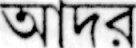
আদর
